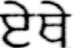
ਏਥੇ
